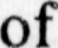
of
